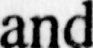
and
